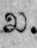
ಖ.
